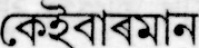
কেইবাৰমান
